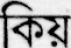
কিয়
